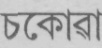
চকোৱা
